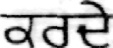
ਕਰਦੇ
